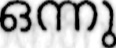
ഒന്നു
